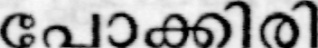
പോക്കിരി
